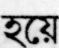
হয়ে
